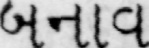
બનાવ
